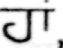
ਹਾਂ,
